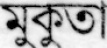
মুকুতা
